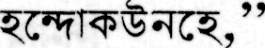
হন্দোকউনহে,”
